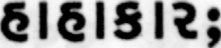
હાહાકાર;
